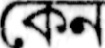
কেন
